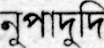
নুপাদুদি
